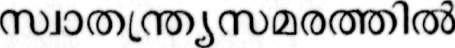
സ്വാതന്ത്ര്യസമരത്തില്‍
